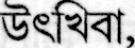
উৎখিবা,
